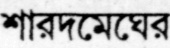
শারদমেঘের
